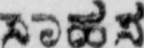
ಸಾಹಸ
